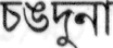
চঙদুনা
